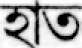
হাত
